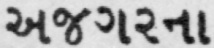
અજગરના
